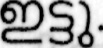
ഇട്ടു.
